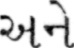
અને
